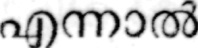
എന്നാല്‍
